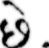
છે.
